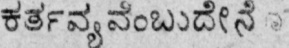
ಕರ್ತವ್ಯವೆಂಬುದೇನೊ
